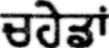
ਚਹੇਡਾਂ
